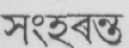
সংহৰন্ত
